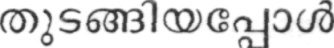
തുടങ്ങിയപ്പോള്‍
